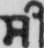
ਸੀ
